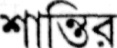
শান্তির
